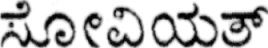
ಸೋವಿಯತ್
